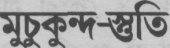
মুচুকুন্দ-স্তুতি
